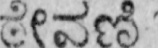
ಠೇವಣಿ
